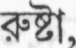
রুষ্টা,
